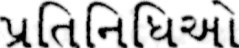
પ્રતિનિધિઓ
